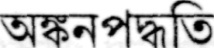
অঙ্কনপদ্ধতি
